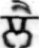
ਲੈ
